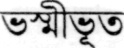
ভস্মীভূত
